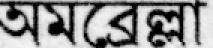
এমব্রেল্লা
